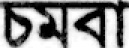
চমবা
